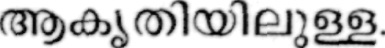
ആകൃതിയിലുള്ള.
